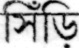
সিঁড়ি
